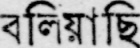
বলিয়াছি
